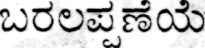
ಬರಲಪ್ಪಣೆಯೆ
